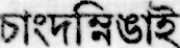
চাংদম্নিঙাই
